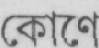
কোণে
